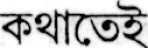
কথাতেই
